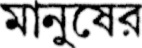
মানুষের
